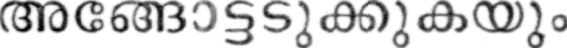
അങ്ങോട്ടടുക്കുകയും
